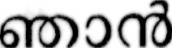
ഞാന്‍
